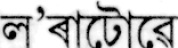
ল'ৰাটোৱে
